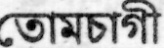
তোমচাগী
